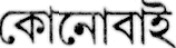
কোনোবাই
